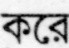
করে
